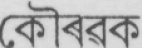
কৌৰৱক
